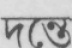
দন্তে
